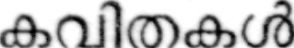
കവിതകള്‍
